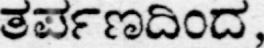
ತರ್ಪಣದಿಂದ,
